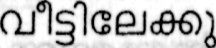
വീട്ടിലേക്കു
